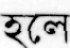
হলে
